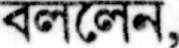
বললেন,
